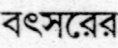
বত্সরের
